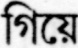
গিয়ে
